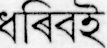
ধৰিবই
